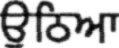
ਉਠਿਆ
